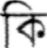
কি
